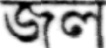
জল
